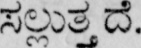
ಸಲ್ಲುತ್ತದೆ.
